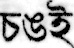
চঙই
